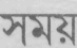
সময়
